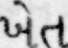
ખેત
